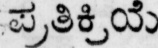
ಪ್ರತಿಕ್ರಿಯೆ
